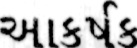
આકર્ષક
